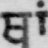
ਥਾਂ
